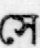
সে
